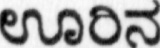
ಊರಿನ
